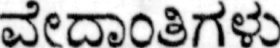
ವೇದಾಂತಿಗಳು
